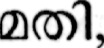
മതി,
